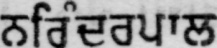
ਨਰਿੰਦਰਪਾਲ
